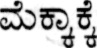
ಮೆಕ್ಕಾಕ್ಕೆ
